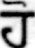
ਹੋ
